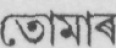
তোমাৰ
